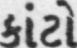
કાંટો
